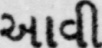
આવી
